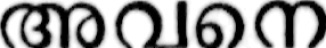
അവനെ
